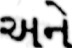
અને
